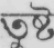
তুষ্ট
